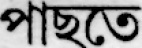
পাছতে
